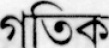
গতিক
